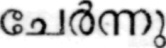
ചേര്‍ന്നു
